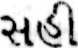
સહી
